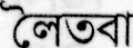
লৈতবা
